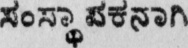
ಸಂಸ್ಥಾಪಕನಾಗಿ
